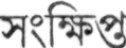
সংক্ষিপ্ত
